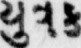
યુવક
